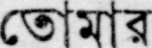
তোমার
